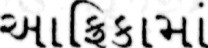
આફ્રિકામાં
